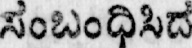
ಸಂಬಂಧಿಸಿದ
